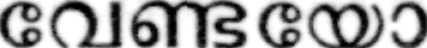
വേണ്ടയോ
